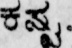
ಕಷ್ಟ.
